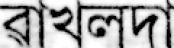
ৱাখলদা
